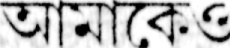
আমাকেও
